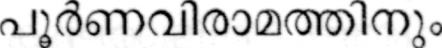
പൂര്‍ണവിരാമത്തിനും
